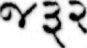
જરૂર
